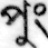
পুং
